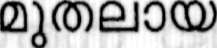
മുതലായ
